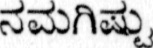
ನಮಗಿಷ್ಟು
